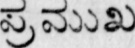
ಪ್ರಮುಖ
